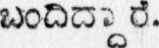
ಬಂದಿದ್ದಾರೆ.
